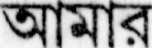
আমার
